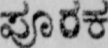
ಪೂರಕ
